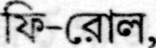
ফি-রোল,
